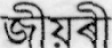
জীয়ৰী
